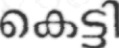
കെട്ടി
